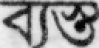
ব্যস্ত
